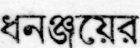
ধনঞ্জয়ের
